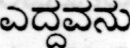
ಎದ್ದವನು
